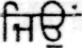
ਜਿਉਂ
